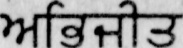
ਅਭਿਜੀਤ
